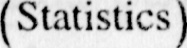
(Statistics)
